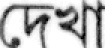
দেখা
